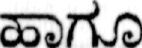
ಹಾಗೂ
